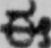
ಈ
